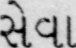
સેવા
